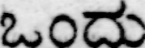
ಒಂದು
